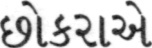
છોકરાએ
